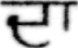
ਦਾ
